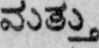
ಮತ್ತು
